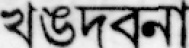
খঙদবনা
